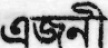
এজনী
